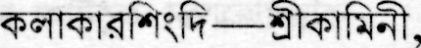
কলাকারশিংদি-শ্রীকামিনী,
